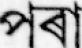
পৰা
